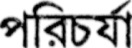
পরিচর্যা
